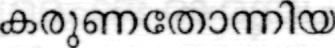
കരുണതോന്നിയ
